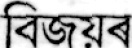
বিজয়ৰ
